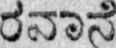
ರವಾನೆ
